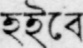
হইবে
